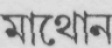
মাথোন
